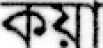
কয়া
